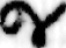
જ
